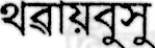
থৱায়বুসু
